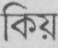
কিয়
